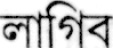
লাগিব
